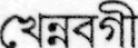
খেন্নবগী
